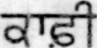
ਕਾਫ਼ੀ
